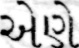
એણે
